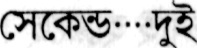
সেকেন্ড....দুই
